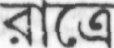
রাত্রে
